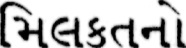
મિલકતનો
